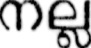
നല്ല
